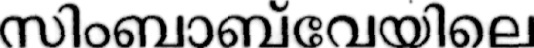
സിംബാബ്വേയിലെ
